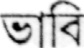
ভাবি
